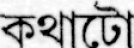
কথাটো
